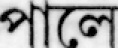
পালে
